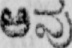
ಅವು
